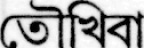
তৌখিবা
